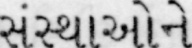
સંસ્થાઓને
